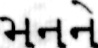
મનને
